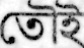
তৌই
